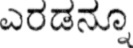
ಎರಡನ್ನೂ
